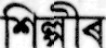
শিল্পীৰ
